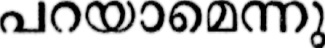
പറയാമെന്നു
